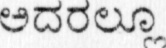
ಅದರಲ್ಲೂ
